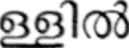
ള്ളില്‍
